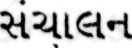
સંચાલન
